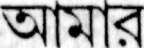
আমার
